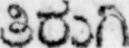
ತಿರುಗಿ
